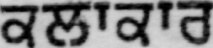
ਕਲਾਕਾਰ
